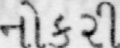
નોકરી
